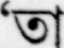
‘তা
